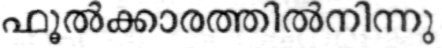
ഫൂല്‍ക്കാരത്തില്‍നിന്നു
